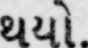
થયો.
